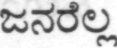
ಜನರೆಲ್ಲ
